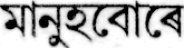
মানুহবোৰে
